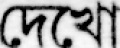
দেখো
